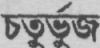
চতুৰ্ভুজ
